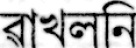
ৱাখলনি
